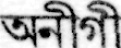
অনীগী
